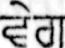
ਵੇਗ
